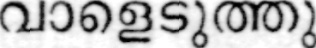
വാളെടുത്തു
